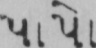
પાપો
